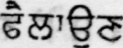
ਫੈਲਾਉਣ
